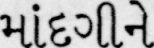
માંદગીને
